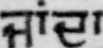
ਜਾਂਦਾ
